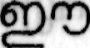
ഈ
